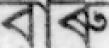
বাৰু
